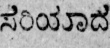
ಸರಿಯಾದ
